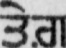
ਤੇਗ਼
